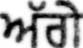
ਅੱਗੇ
